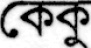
কেকু
